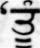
'ਤੂੰ
